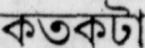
কতকটা
